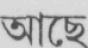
আছে
